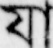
যা
